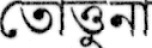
তোত্তুনা
